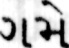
ગમે
